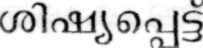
ശിഷ്യപ്പെട്ട്
